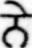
ਨੇ
